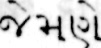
જેમણે
